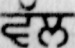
ਵੱਲ
